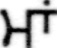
ਮਾਂ
